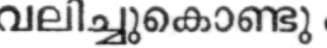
വലിച്ചുകൊണ്ടു
